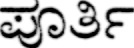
ಪೂರ್ತಿ
